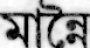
মান্নৈ
